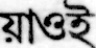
য়াওই
